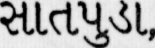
સાતપુડા,
